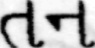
તન
